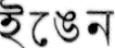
ইঙেন
